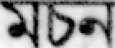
মচন
